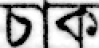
চাক
